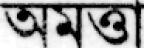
অমত্তা
